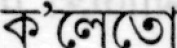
ক'লেতো
